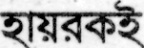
হায়রকই
